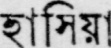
হাসিয়া
